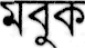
মবুক
